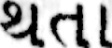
થતા
